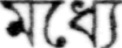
মধ্যে
